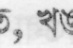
খঙ
